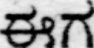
ಈಗ
